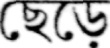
ছেড়ে
